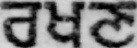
ਰਖਣ
